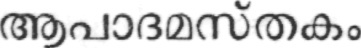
ആപാദമസ്തകം
